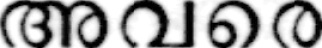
അവരെ
